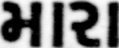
મારા
